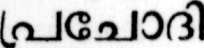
പ്രചോദി
